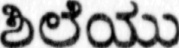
ಶಿಲೆಯು
